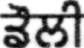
ਡੌਲੀ
